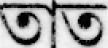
তাত
